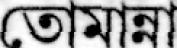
তোমান্না
